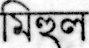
মিহুল
